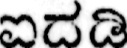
ಐದಡಿ
